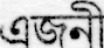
এজনী
